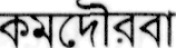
কমদৌরবা
